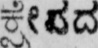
ಕ್ಷೇಪದ
